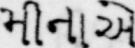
મીનાએ
